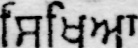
ਸਿਖਿਆ
